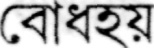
বোধহয়
